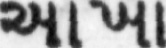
આખા
